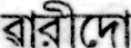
ৱারিদো
